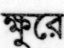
ক্ষুরে
